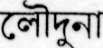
লৌদুনা
